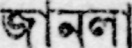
জানলা
